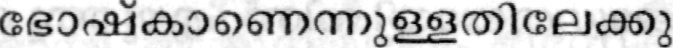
ഭോഷ്കാണെന്നുള്ളതിലേക്കു
